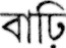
বাঢ়ি
